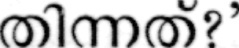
തിന്നത്?'
